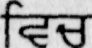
ਵਿਚ
